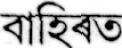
বাহিৰত
